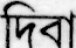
দিবা
